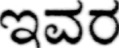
ಇವರ
